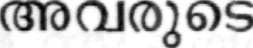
അവരുടെ
